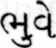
ભુવે
